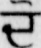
ਦੋ
